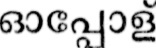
ഓപ്പോള്
